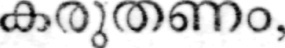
കരുതണം,
